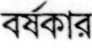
বর্ষকার
